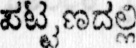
ಪಟ್ಟಣದಲ್ಲಿ
